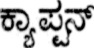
ಕ್ಯಾಪ್ಟನ್
